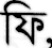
ফি,
